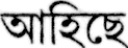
আহিছে
